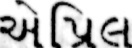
એપ્રિલ
